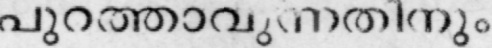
പുറത്താവുന്നതിനും
